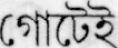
গোটেই
